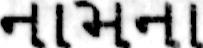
નામના
